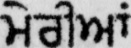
ਮੇਰੀਆਂ
